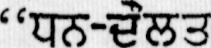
''ਧਨ-ਦੌਲਤ
